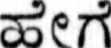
ಹೇಗೆ
